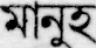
মানুহ
